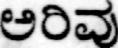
ಅರಿವು
